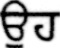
ਉਹ
